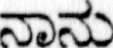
ನಾನು
